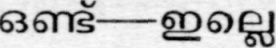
ഒണ്ട്-ഇല്ലെ
